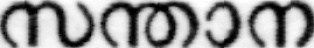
സന്താന
